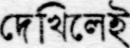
দেখিলেই
